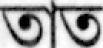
তাত
